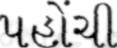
પહોચી
